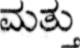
ಮತ್ತು
